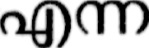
എന്ന
